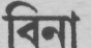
বিনা
